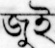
জুই
